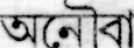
অনৌবা
